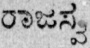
ರಾಜಸ್ವ
